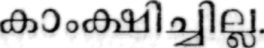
കാംക്ഷിച്ചില്ല.
